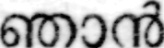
ഞാന്‍
